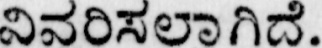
ವಿವರಿಸಲಾಗಿದೆ.
